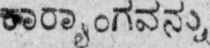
ಕಾರ್‍ಯಾಂಗವನ್ನು
